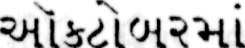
ઑક્ટોબરમાં
